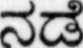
ನಡೆ
